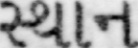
સ્થાન
